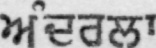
ਅੰਦਰਲਾ
